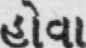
હોવા
